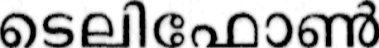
ടെലിഫോണ്‍
